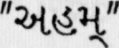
અહમ્"
